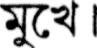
মুখে।
